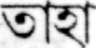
তাহা
